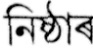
নিষ্ঠাৰ
